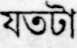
যতটা
